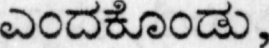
ಎಂದಕೊಂಡು,
